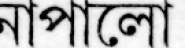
নাপালো
